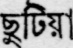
ছুটিয়া
